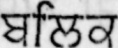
ਬਲਿਕ
